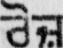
ਰੋਜ਼
